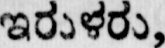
ಇರುಳರು,
